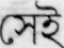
সেই
